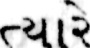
ત્યારે
